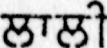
ਲਾਲੀ
